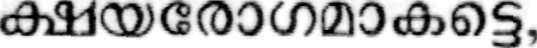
ക്ഷയരോഗമാകട്ടെ,
